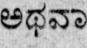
ಅಥವಾ
